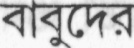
বাবুদের
